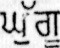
ਘੁੱਗੂ
